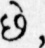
છે,
